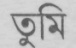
তুমি
